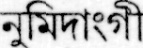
নুমিদাংগী
